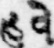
હવે
